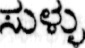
ಸುಳ್ಳು
